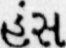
હંસ
